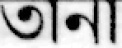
তানা
